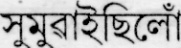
সুমুৱাইছিলোঁ
